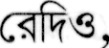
রেদিও,
